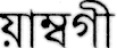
য়াম্বগী
